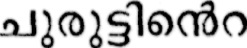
ചുരുട്ടിന്റെ
